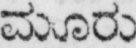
ಮೂರು
